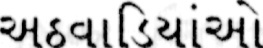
અઠવાડિયાંઓ
